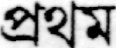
প্রথম
